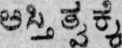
ಅಸ್ತಿತ್ವಕ್ಕೆ
